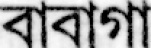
বাবাগা
